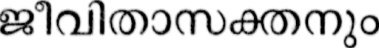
ജീവിതാസക്തനും
